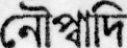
নৌপ্বাদি
